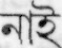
নাই
